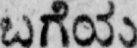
ಬಗೆಯ
